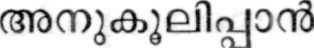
അനുകൂലിപ്പാന്‍
